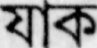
যাক
